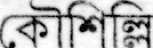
কৌশিল্লি
